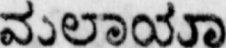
ಮಲಾಯಾ
